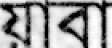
য়াবা
